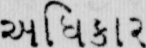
અધિકાર
